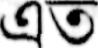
এত
